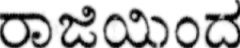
ರಾಜಿಯಿಂದ
